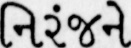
નિરંજને
